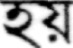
হয়
